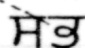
ਸਭ
